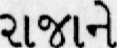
રાજાને
